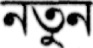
নতুন
